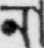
না
